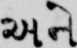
અને
